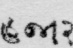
હજાર
